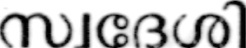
സ്വദേശി
